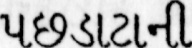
પછડાટાની
